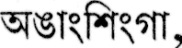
অঙাংশিংগা,
